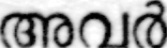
അവര്‍
